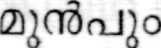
മുന്‍പും
